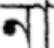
না
